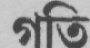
গতি
